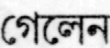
গেলেন
